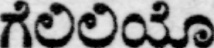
ಗೆಲಿಲಿಯೊ
